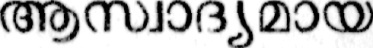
ആസ്വാദ്യമായ
